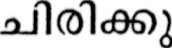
ചിരിക്കു
